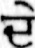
ਦੇ
